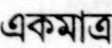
একমাত্র
